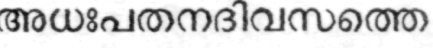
അധഃപതനദിവസത്തെ
